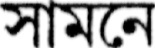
সামনে
